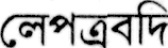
লেপত্রবদি
